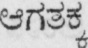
ಆಗತಕ್ಕ
